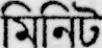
মিনিট
